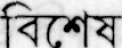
বিশেষ
